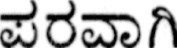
ಪರವಾಗಿ
